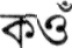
কওঁ
